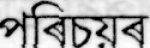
পৰিচয়ৰ
